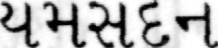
યમસદન
